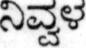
ನಿವ್ವಳ
